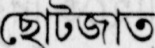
ছোটজাত
